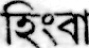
হিংবা
